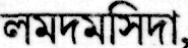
লমদমসিদা,
